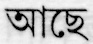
আছে
